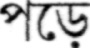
পড়ে
